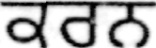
ਕਰਨ
